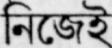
নিজেই
